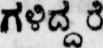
ಗಳಿದ್ದರೆ
